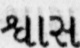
શ્વાસ
